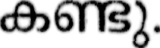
കണ്ടു.
